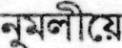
নুমলীয়ে
